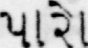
પારો
